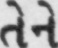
તેને
